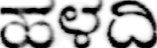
ಹಳದಿ
